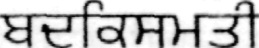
ਬਦਕਿਸਮਤੀ
